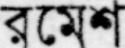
রমেশ
